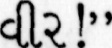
વીર!"
